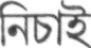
নিচাই
